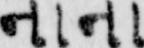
નાના
